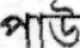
পাউ
